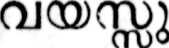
വയസ്സു
